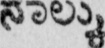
ನಾಲ್ಕು
